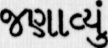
જણાવ્યું
